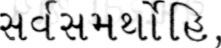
સર્વસમર્થોહિ,
